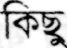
কিছু
